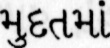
મુદતમાં
